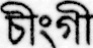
চীংগী
